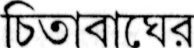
চিতাবাঘের
